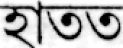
হাতত
